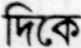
দিকে
